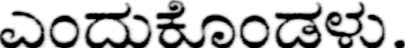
ಎಂದುಕೊಂಡಳು.
